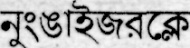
নুংঙাইজরক্লে
